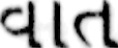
વાત
